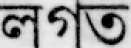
লগত
